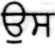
ਉਸ
